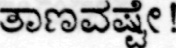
ತಾಣವಷ್ಟೇ!
